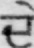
ਦੇ
